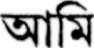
আমি
